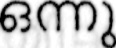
ഒന്നു
